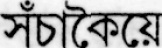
সঁচাকৈয়ে
